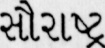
સૌરાષ્ટ્ર
